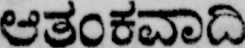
ಆತಂಕವಾದಿ
